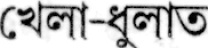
খেলা-ধুলাত
